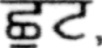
ਛੁਟ,
